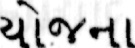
યોજના
